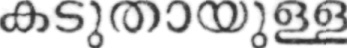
കടുതായുള്ള
